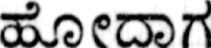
ಹೋದಾಗ
